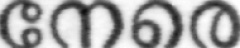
നേരെ
